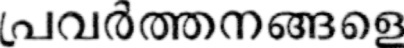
പ്രവര്‍ത്തനങ്ങളെ
